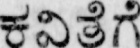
ಕವಿತೆಗೆ
